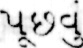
પૂછવું
